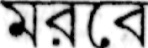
মরবে
